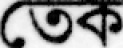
তেক
